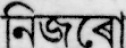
নিজৰো
